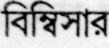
বিম্বিসার
